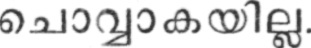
ചൊവ്വാകയില്ല.
